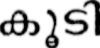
കൂടി
